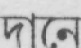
দানে
